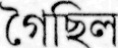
গৈছিল
